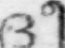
ദീ
